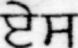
ਏਸ
